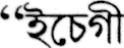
“ইচেগী
